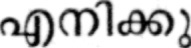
എനിക്കു
